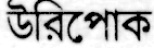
উরিপোক
